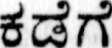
ಕಡೆಗೆ
